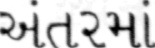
અતંરમાં
